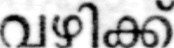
വഴിക്ക്
